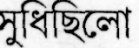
সুধিছিলো
